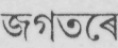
জগতৰে
